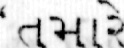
'તમારે
